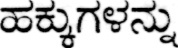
ಹಕ್ಕುಗಳನ್ನು
